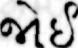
જોઈ
